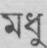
মধু
